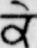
ਕੇ
